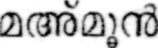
മഅ്മൂന്‍
